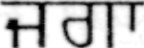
ਜਗਾ
